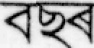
বছৰ
